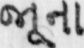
જૂના
